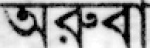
অরুবা
